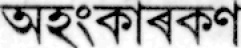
অহংকাৰকণ
